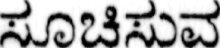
ಸೂಚಿಸುವ
